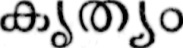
കൃത്യം
